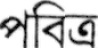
পবিত্র
